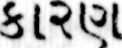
કારણ
